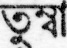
তুম্বা
